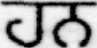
ਹਨ
